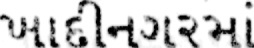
ખાદીનગરમાં
